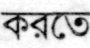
করতে
